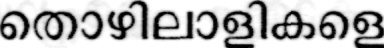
തൊഴിലാളികളെ
